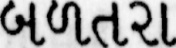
બળતરા
